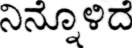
ನಿನ್ನೊಳಿದೆ
